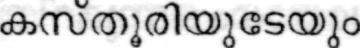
കസ്തൂരിയുടേയും
